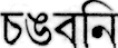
চঙবনি
